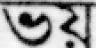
ভয়
